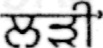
ਲੜੀ'
